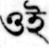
ওই
